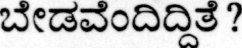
ಬೇಡವೆಂದಿದ್ದಿತೆ?
